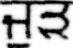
ਜੁੜ
